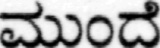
ಮುಂದೆ
